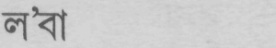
ল'বা
